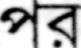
পর
